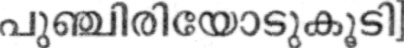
പുഞ്ചിരിയോടുകൂടി]
